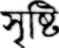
সৃষ্টি
